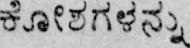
ಕೋಶಗಳನ್ನು
